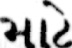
માટે
